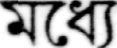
মধ্যে
